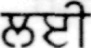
ਲਈ
